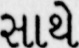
સાથે
